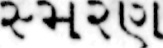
સ્મરણ
